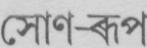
সোণ-ৰূপ
